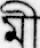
মী
